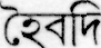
হৈবদি
